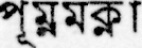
পূম্নমক্না
